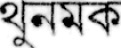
থুনমক
